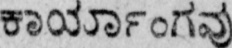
ಕಾರ್ಯಾಂಗವು
